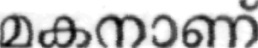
മകനാണ്
